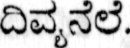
ದಿವ್ಯನೆಲೆ.
